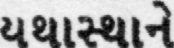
યથાસ્થાને
